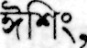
ঈশিং,
